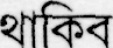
থাকিব
